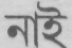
নাই
